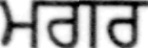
ਮਗਰ
